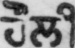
ਹੌਲੀ
